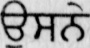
ਉਸਨੇ
